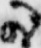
જે
